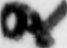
જ
